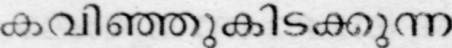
കവിഞ്ഞുകിടക്കുന്ന
